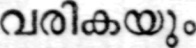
വരികയും
